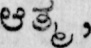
ಆತ್ಮ,
